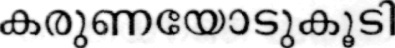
കരുണയോടുകൂടി
